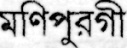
মণিপুরগী
